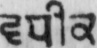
ਵਧੀਕ
